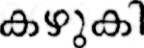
കഴുകി
